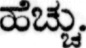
ಹೆಚ್ಚು.
